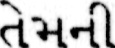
તેમની
